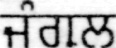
ਜੰਗਲ
